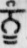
ਨੂੰ
